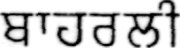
ਬਾਹਰਲੀ
